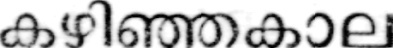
കഴിഞ്ഞകാല
